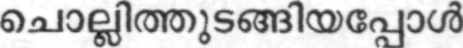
ചൊല്ലിത്തുടങ്ങിയപ്പോള്‍
